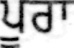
ਪੂਰਾ
